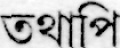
তথাপি
